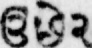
ઉછેર
